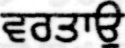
ਵਰਤਾਉ
